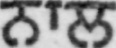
ਨਾਲ
